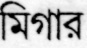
মিগার
